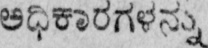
ಅಧಿಕಾರಗಳನ್ನು
